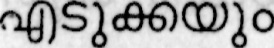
എടുക്കയും
